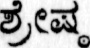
ಶ್ರೇಷ್ಠ
